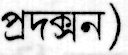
প্রদক্সন)
